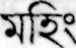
মহিং
